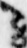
કે
